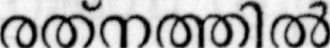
രത്നത്തില്‍
